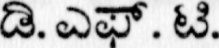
ಡಿ.ಎಫ್.ಟಿ.
